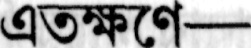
এতক্ষণে–
